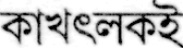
কাখৎলকই
